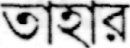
তাহার
